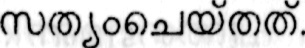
സത്യംചെയ്തത്.
